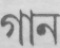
গান
